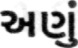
અણું
